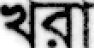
খরা
